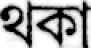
থকা
